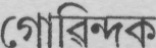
গোৱিন্দক
